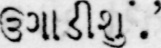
ઉગાડીશું.'
